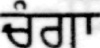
ਚੰਗਾ
